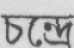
চন্দ্ৰে
